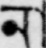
না
